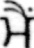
ਮੈਂ
